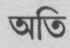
অতি
